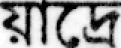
য়াদ্রে
